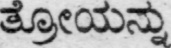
ತ್ರೋಯನ್ನು
